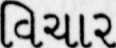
વિચાર
